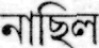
নাছিল
